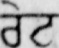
ਰੇਟ
